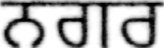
ਨਗਰ
